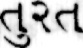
તુરત
